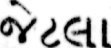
જેટલા
